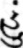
હું
